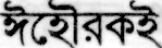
ঈহৌরকই
